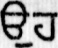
ਉਹ
